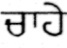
ਚਾਹੇ
